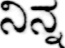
ನಿನ್ನ
